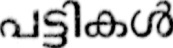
പട്ടികള്‍
